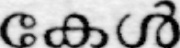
കേള്‍
